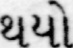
થયો
